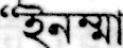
“ইনম্মা
